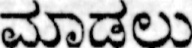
ಮಾಡಲು
